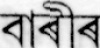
বাৰীৰ
